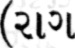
(રાગ
